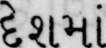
દેશમાં
